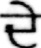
ਦੇ
